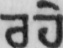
ਰਹੇ
